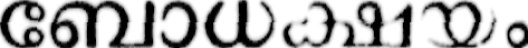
ബോധക്ഷയം
